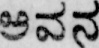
ಅವನ
